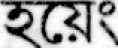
হয়েং
